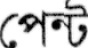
পেন্ট
